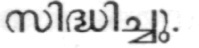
സിദ്ധിച്ചു.
